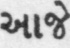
આજે
